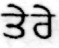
ਤੇਰੇ
